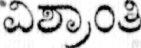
ವಿಶ್ರಾಂತಿ
